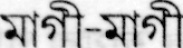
মাগী-মাগী
